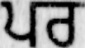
ਪਰ
